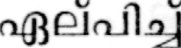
ഏല്പിച്ച്
